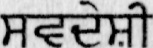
ਸਵਦੇਸ਼ੀ
